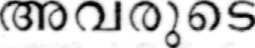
അവരുടെ
